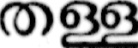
തള്ള
